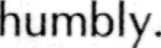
humbly.
